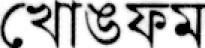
খোঙফম
